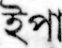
ইপা
